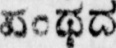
ಪಂಥದ
